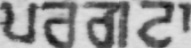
ਪਰਗਟਾ
